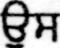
ਉਸ
